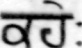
ਕਹੇ:
